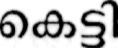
കെട്ടി
